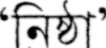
‘নিষ্ঠা’
